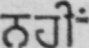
ਨਹੀਂ
